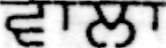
ਵਾਲਾ
